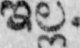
ಇಲ್ಲ.
